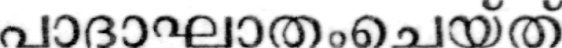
പാദാഘാതംചെയ്ത്
